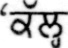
'ਕੱਲ੍ਹ
